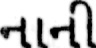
નાની
